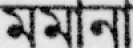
মমানা
